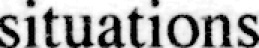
situations
